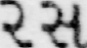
રસ
